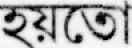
হয়তো
